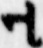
ન
